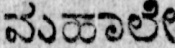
ಮಹಾಲೇ
